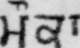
ਮੌਕਾ
